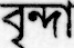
বৃন্দা
